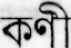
কণী
